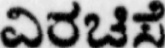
ವಿರಚಿಸೆ
